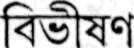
বিভীষণ
